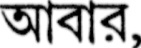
আবার,
